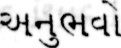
અનુભવો
